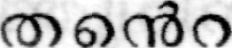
തന്റെ
